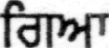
ਗਿਆ
